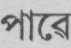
পাৱে
